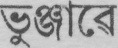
ভুঞ্জাৱে
